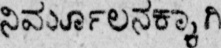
ನಿರ್ಮೂಲನಕ್ಕಾಗಿ
